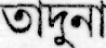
তাদুনা
